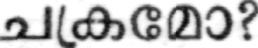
ചക്രമോ?
